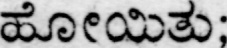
ಹೋಯಿತು;
